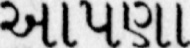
આપણા
